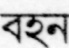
বহন
